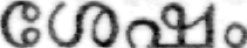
ശേഷം
